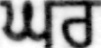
ਘਰ
